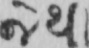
જેથી
